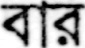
বার
